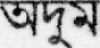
অদুম
